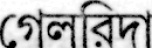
গেলরিদা
